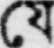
যে
